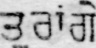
ਤੁਰਾਂਗੇ
